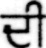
ਦੀ
